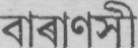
বাৰাণসী
